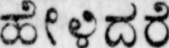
ಹೇಳಿದರೆ
